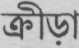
ক্ৰীড়া
